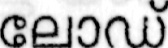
ലോഡ്
